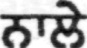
ਨਾਲੇ
